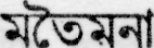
মতৈমনা
